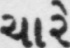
ચારે
